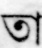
তা
